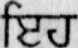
ਇਹ
